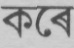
কৰে
